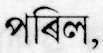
পৰিল,
